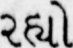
રહ્યો
